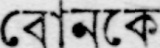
বোনকে
